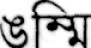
ঙম্মী
